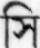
সি
